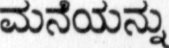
ಮನೆಯನ್ನು
